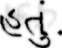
હતું.
